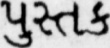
પુસ્તક
